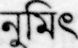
নুমিৎ
